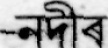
নদীৰ
